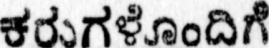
ಕರುಗಳೊಂದಿಗೆ
